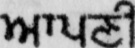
ਆਪਣੀ
